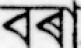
বৰা
